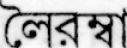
লৈরম্বা
